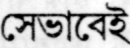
সেভাবেই
